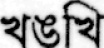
খঙখি
